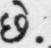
છે.
